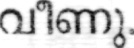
വീണു.
